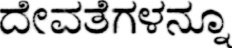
ದೇವತೆಗಳನ್ನೂ
